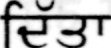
ਦਿੱਤਾ
